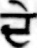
ਦੇ
